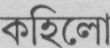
কহিলো
